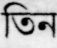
তিন
